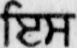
ਇਸ
